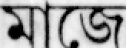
মাজে
